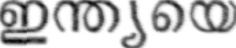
ഇന്ത്യയെ
